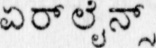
ಏರ್‌ಲೈನ್ಸ್
